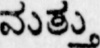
ಮತ್ತು
